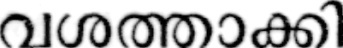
വശത്താക്കി
